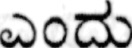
ಎಂದು
